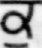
ਕੁ
